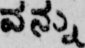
ವನ್ನು
